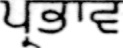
ਪ੍ਰਭਾਵ
